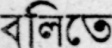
বলিতে
